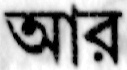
আর
